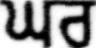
ਘਰ
